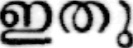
ഇതു
